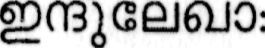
ഇന്ദുലേഖാ:
